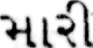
મારી
